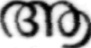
ആ
